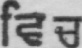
ਵਿਚ
